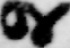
જ
